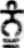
ਨੂੰ
